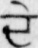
ਦੇ
